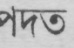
পদত
